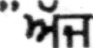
''ਅੱਜ
